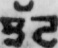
ਝੱਟ
